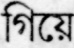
গিয়ে
